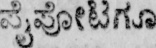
ಪೈಪೋಟಿಗೂ
